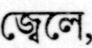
জ্বেলে,
